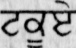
ਟਕੂਏ
